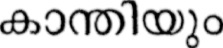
കാന്തിയും
